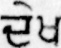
ਦੇਖ
